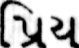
પ્રિય
